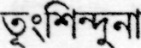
তূংশিন্দুনা
